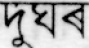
দুঘৰ
